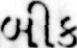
બીક
